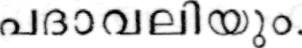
പദാവലിയും.
